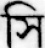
সি
